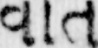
વાત
